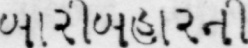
બારીબહારની
